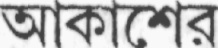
আকাশের
